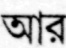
আর
